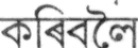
কৰিবলৈ
